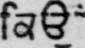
ਕਿਉਂ
